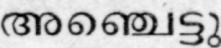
അഞ്ചെട്ടു
